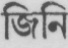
জিনি
